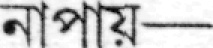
নাপায়-
